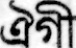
ঐগী
